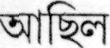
আছিল
